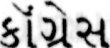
કૉંગ્રેસ
